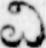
ವಿ
